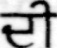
ਦੀ
